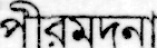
পীরমদনা
